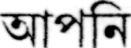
আপনি
